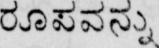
ರೂಪವನ್ನು
